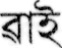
ৱাই
